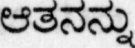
ಆತನನ್ನು
